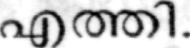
എത്തി.
